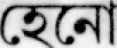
হেনো
